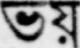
ভয়
